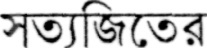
সত্যজিতের
